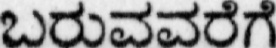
ಬರುವವರೆಗೆ
